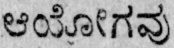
ಆಯೋಗವು
